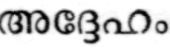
അദ്ദേഹം
